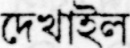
দেখাইল
